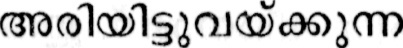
അരിയിട്ടുവയ്ക്കുന്ന
